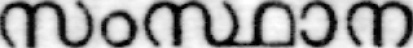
സംസ്ഥാന
